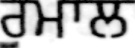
ਰੁਮਾਲ
